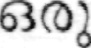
ഒരു
